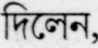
দিলেন,
